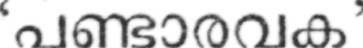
‘പണ്ടാരവക'
